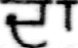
ਦਾ
